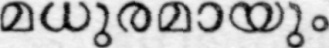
മധുരമായും
